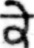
ਕੇ
